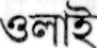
ওলাই
